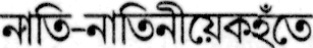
নাতি-নাতিনীয়েকহঁতে
